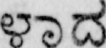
ಳಾದ
